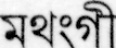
মথংগী
